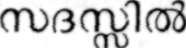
സദസ്സില്‍
